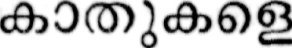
കാതുകളെ
